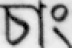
চাং
